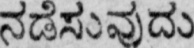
ನಡೆಸುವುದು
